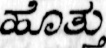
ಹೊತ್ತು
